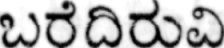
ಬರೆದಿರುವಿ
